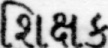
શિક્ષક
